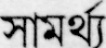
সামর্থ্য
